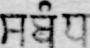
ਸਬੰਧ
